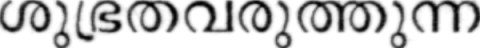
ശുഭ്രതവരുത്തുന്ന
